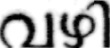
വഴി
